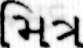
મિત્ર
